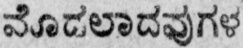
ಮೊದಲಾದವುಗಳ
